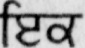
ਇਕ
